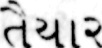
તૈયાર
